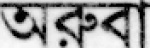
অরুবা
